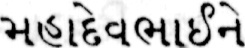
મહાદેવભાઈને
